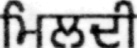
ਮਿਲਦੀ
